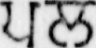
ਪਲ
